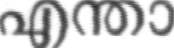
എന്താ
